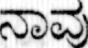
ನಾವು
